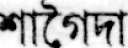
শাগৈদা
